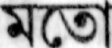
মতো
